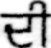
ਦੀ
